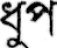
ধুপ
